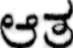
ಆತ
